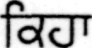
ਕਿਹਾ
